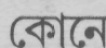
কোনে
